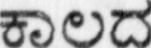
ಕಾಲದ
